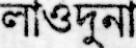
লাওদুনা
